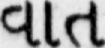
વાત
